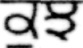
ਕੁਝ
